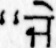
''ਜੇ
